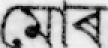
মোৰ
